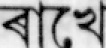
ৰাখে
